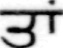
ਤਾਂ
